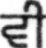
ਵੀ
